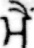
ਮੈਂ
